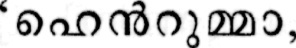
‘ഹെൻറുമ്മാ,
